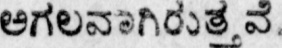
ಅಗಲವಾಗಿರುತ್ತವೆ.
